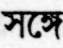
সঙ্গে
